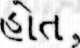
હોત,
